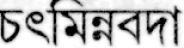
চৎমিন্নবদা
